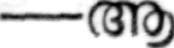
-ആ
